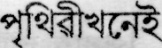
পৃথিৱীখনেই
